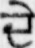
ਦੇ
